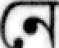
নে
